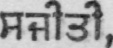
ਸਜੀਤੀ,
